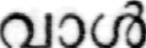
വാള്‍
